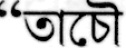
“তাচৌ
